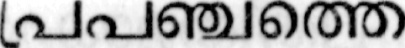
പ്രപഞ്ചത്തെ
